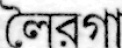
লৈরগা
